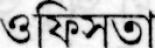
ওফিসতা
